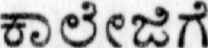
ಕಾಲೇಜಿಗೆ
